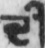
ਦੀ
